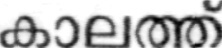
കാലത്ത്
